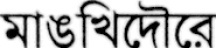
মাঙখিদৌরে
